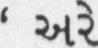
'અરે
